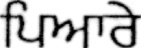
ਪਿਆਰੇ
